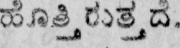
ಹೊತ್ತಿರುತ್ತದೆ.
